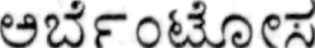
ಅರ್ಬೆಂಟೋಸ
